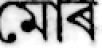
মোৰ
